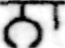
ਨਾ
